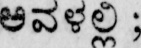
ಅವಳಲ್ಲಿ;
